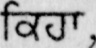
ਕਿਹਾ,
